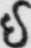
ઈ
